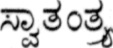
ಸ್ವಾತಂತ್ರ್ಯ
